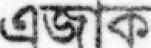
এজাক
